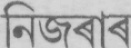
নিজৰাৰ
